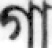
গা
